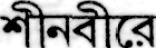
শীনবীরে
